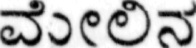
ಮೇಲಿನ
